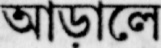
আড়ালে
